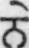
ਨੇ
